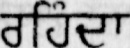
ਰਹਿੰਦਾ
